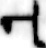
ન
